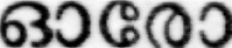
ഓരോ
